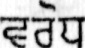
ਵਰੋਧ
